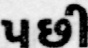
પછી
